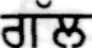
ਗੱਲ
